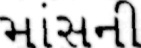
માંસની
